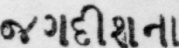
જગદીશના
